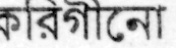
করিগীনো
